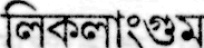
লিকলাংগুম
